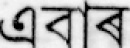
এবাৰ
